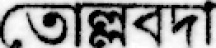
তোল্লবদা
